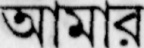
আমার
